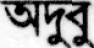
অদুবু
